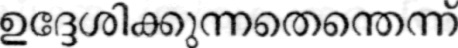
ഉദ്ദേശിക്കുന്നതെന്തെന്ന്
